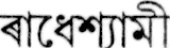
ৰাধেশ্যামী
